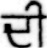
ਦੀ
